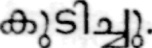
കുടിച്ചു.
